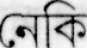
নেকি
